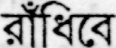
রাঁধিবে
